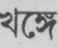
খঙ্গে
